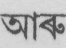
আৰু
